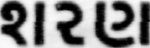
શરણ
